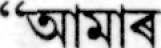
"আমাৰ
